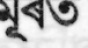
মূৰত
